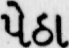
પેઠા
